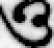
ও
